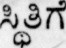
ಸ್ಥಿತಿಗೆ
